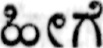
ಹೀಗೆ
